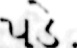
પડે.
